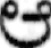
ಆ
